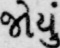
જોયું
